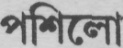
পশিলো
